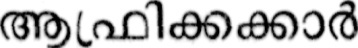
ആഫ്രിക്കക്കാര്‍
